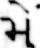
મેં
